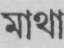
মাথা
